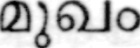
മുഖം
